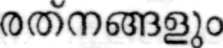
രത്നങ്ങളും
